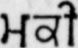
ਮਕੀ
